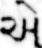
એ
